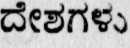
ದೇಶಗಳು
